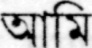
আমি
